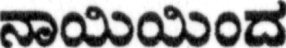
ನಾಯಿಯಿಂದ
